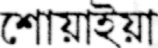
শোয়াইয়া
